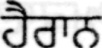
ਹੈਰਾਨ
